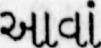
આવાં
